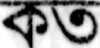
কত
